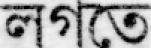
লগতে
